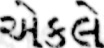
એકલે
